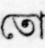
তো
